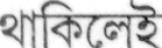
থাকিলেই
